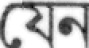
যেন
